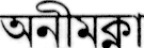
অনীমক্তা
